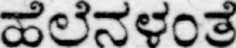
ಹೆಲೆನಳಂತೆ
